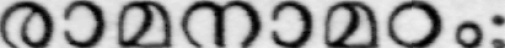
രാമനാമഠം:
